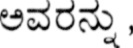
ಅವರನ್ನು,
